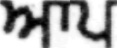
ਆਪ
